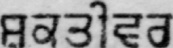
ਸ਼ਕਤੀਵਰ
